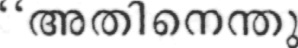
"അതിനെന്തു
